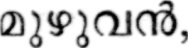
മുഴുവന്‍,
